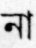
না
